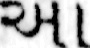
આ
